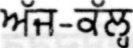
ਅੱਜ-ਕੱਲ੍ਹ
